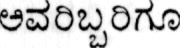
ಅವರಿಬ್ಬರಿಗೂ
